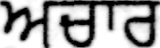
ਅਚਾਰ
